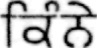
ਕਿੰਨੇ
